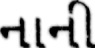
નાની
